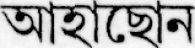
আহাছোন
